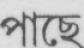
পাছে
